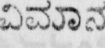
ವಿಮಾನ
